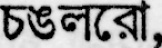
চঙলরো,
